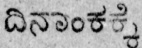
ದಿನಾಂಕಕ್ಕೆ
